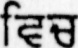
ਵਿਚ
